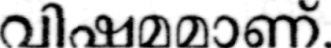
വിഷമമാണ്.
